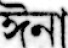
ঈনা
